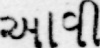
આવી
